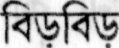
বিড়বিড়
